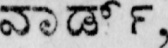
ವಾರ್ಡ್,
